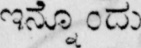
ಇನ್ನೊಂದು
